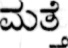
ಮತ್ತೆ
